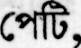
পেটি,
